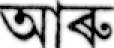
আৰু
